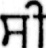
ਸੀ
